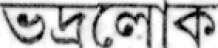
ভদ্রলোক
